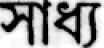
সাধ্য
